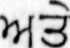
ਅਤੇ
